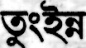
তুংইন্ন
